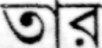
তার
